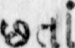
છતાં
